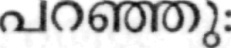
പറഞ്ഞു:
